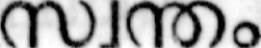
സ്വന്തം
